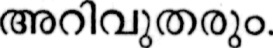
അറിവുതരും.
